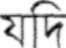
যদি
